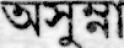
অসুম্না
